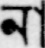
না
